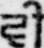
ਵੀ
